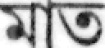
মাত
